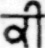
ਕੀ
